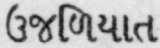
ઉજળિયાત
